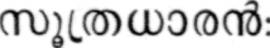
സൂത്രധാരന്‍:
